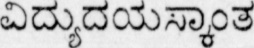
ವಿದ್ಯುದಯಸ್ಕಾಂತ
